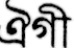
ঐগী
